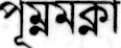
পূম্নমক্না
